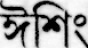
ঈশিং
